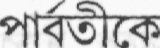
পার্বতীকে
